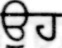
ਉਹ
